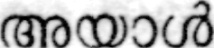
അയാള്‍
